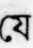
যে
